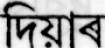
দিয়াৰ
